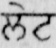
ਲੇਟ
